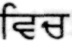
ਵਿਚ
